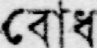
বোধ
